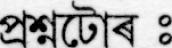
প্রশ্নটোৰঃ
